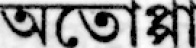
অতোপ্পা
